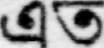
এত
